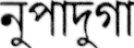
নুপাদুগা
